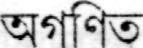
অগণিত
